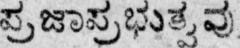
ಪ್ರಜಾಪ್ರಭುತ್ವವು
